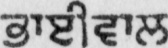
ਭਾਈਵਾਲ
